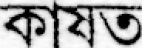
কাষত
